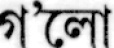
গ'লো
